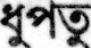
ধুপতু
